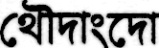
থৌদাংদো
